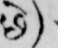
છે)
